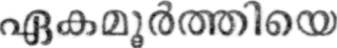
ഏകമൂര്‍ത്തിയെ
